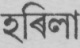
হৰিলা
